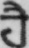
ਹੈ
